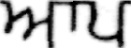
ਆਪ
